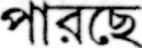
পারছে
